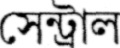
সেন্ট্রাল
